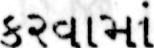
કરવામાં
